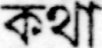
কথা
